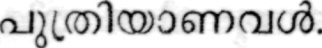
പുത്രിയാണവള്‍.
